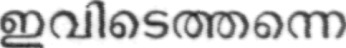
ഇവിടെത്തന്നെ
